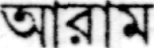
আরাম
